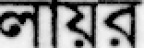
লায়র
